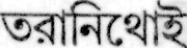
তরানিথোই
